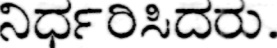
ನಿರ್ಧರಿಸಿದರು.
